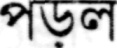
পড়ল
